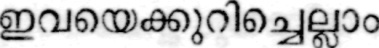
ഇവയെക്കുറിച്ചെല്ലാം
